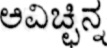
ಅವಿಚ್ಛಿನ್ನ
